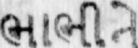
ભાભીને
